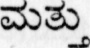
ಮತ್ತು
